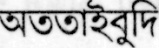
অততাইবুদি
